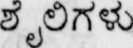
ಶೈಲಿಗಳು
